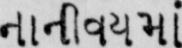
નાનીવયમાં
